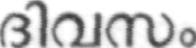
ദിവസം
